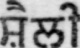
ਸ਼ੈਲੀ
